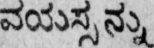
ವಯಸ್ಸನ್ನು
